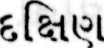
દક્ષિણ
